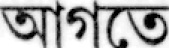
আগতে
